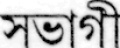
সভাগী
